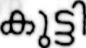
കുട്ടി
